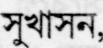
সুখাসন,
